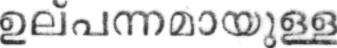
ഉല്പന്നമായുള്ള
